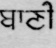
ਬਾਣੀ
